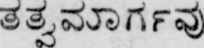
ತತ್ವಮಾರ್ಗವು
